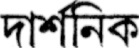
দার্শনিক
